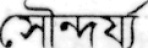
সৌন্দৰ্য্য
